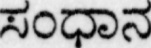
ಸಂಧಾನ
